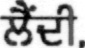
ਲੈਂਦੀ,
